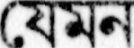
যেমন
